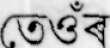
তেওঁৰ
